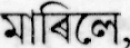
মাৰিলে,
